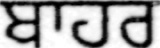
ਬਾਹਰ
